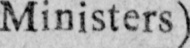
Ministers)
